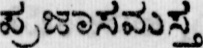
ಪ್ರಜಾಸಮಸ್ತ
